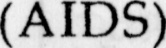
(AIDS)
